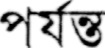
পর্যন্ত
